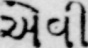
એવી
